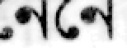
নেনে
